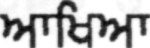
ਆਖਿਆ
